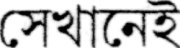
সেখানেই
